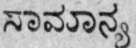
ಸಾಮಾನ್ಯ
